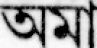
অমা
